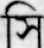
সি
